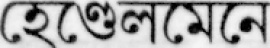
হেণ্ডেলমেনে
